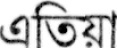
এতিয়া
